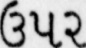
ઉપર
